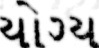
યોગ્ય
